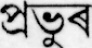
প্রভুৰ
